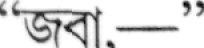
"জবা,-"
